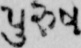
પુરુષ
